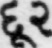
દૂર
